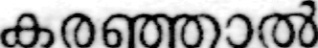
കരഞ്ഞാല്‍
